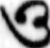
ও
